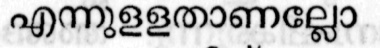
എന്നുളളതാണല്ലോ
